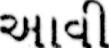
આવી
